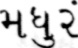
મધુરં
